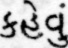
કહેવું
